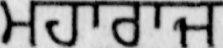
ਮਹਾਰਾਜ
